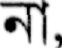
না,
